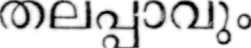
തലപ്പാവും
